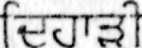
ਦਿਹਾੜੀ
